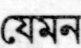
যেমন
